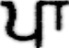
ਪਾ
